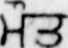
ਮੌਤ
